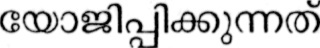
യോജിപ്പിക്കുന്നത്
